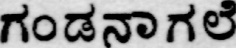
ಗಂಡನಾಗಲೆ
